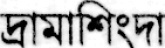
দ্রামাশিংদা
